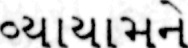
વ્યાયામને
